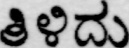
ತಿಳಿದು
